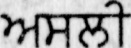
ਅਸਲੀ
